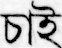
চাই
